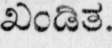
ಖಂಡಿತ.
